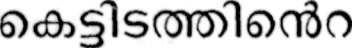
കെട്ടിടത്തിന്റെ
